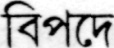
বিপদে
